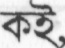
কই,
